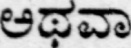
ಅಥವಾ
